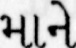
માને
